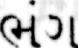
ભંગ
